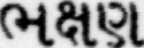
ભક્ષણ
